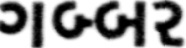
ગબ્બર
